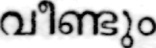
വീണ്ടും
